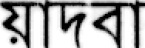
য়াদবা
